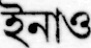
ইনাও
